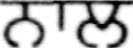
ਨਾਲ
